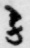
કે
